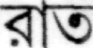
রাত
